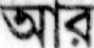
আর
